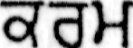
ਕਰਮ
